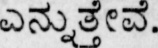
ಎನ್ನುತ್ತೇವೆ.
